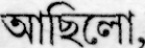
আছিলো,
